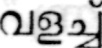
വളച്ച്
